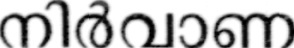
നിര്‍വാണ
